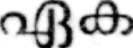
ഏക
